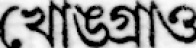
খোঙগ্রাও
